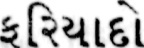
ફરિયાદો
